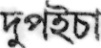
দুপইচা
